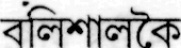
বলিশালকৈ
